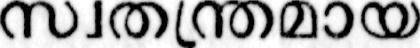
സ്വതന്ത്രമായ
